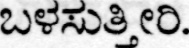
ಬಳಸುತ್ತೀರಿ.
